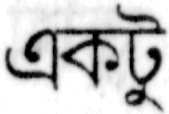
একটু
